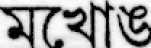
মখোঙ
